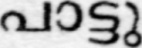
പാട്ടു
